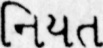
નિયત
